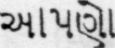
આપણો
